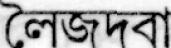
লৈজদবা
